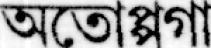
অতোপ্পগা
